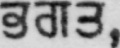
ਭਗਤ,
